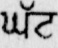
ਘੱਟ
